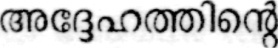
അദ്ദേഹത്തിന്റെ
